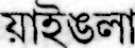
য়াইঙলা
